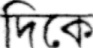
দিকে
